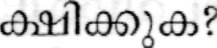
ക്ഷിക്കുക?
